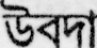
উবদা
